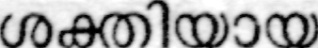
ശക്തിയായ
